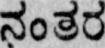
ನಂತರ
